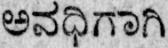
ಅವಧಿಗಾಗಿ
